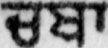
ਚਬਾ
